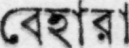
বেহারা
